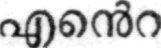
എന്റെ
